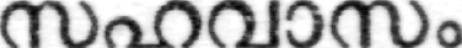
സഹവാസം
